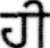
ਹੀ
